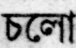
চলো
